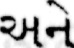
અને
